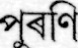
পুৰণি
